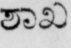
ಶಾಖ
